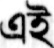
এই
